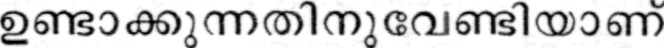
ഉണ്ടാക്കുന്നതിനുവേണ്ടിയാണ്
